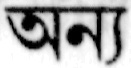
অন্য
